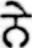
ਨੇ
